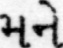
મને
